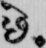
છે.
